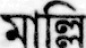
মাল্লি
